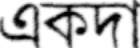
একদা
